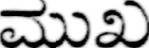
ಮುಖ
